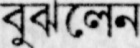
বুঝলেন
